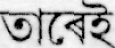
তাৰেই
